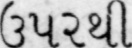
ઉપરથી
